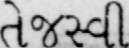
તેજસ્વી
